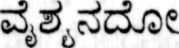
ವೈಶ್ಯನದೋ
